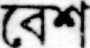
বেশ
